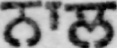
ਨਾਲ
